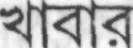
খাবার
